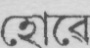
হোৱে
